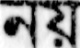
নয়
